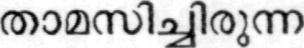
താമസിച്ചിരുന്ന
